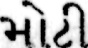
મોટી
